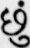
છું
